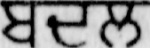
ਬਦਲ
